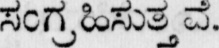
ಸಂಗ್ರಹಿಸುತ್ತವೆ.
